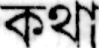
কথা
